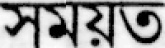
সময়ত
